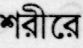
শরীরে
